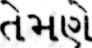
તેમણે
